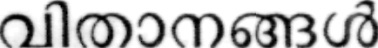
വിതാനങ്ങള്‍
